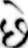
છે
